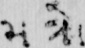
મંત્રો
